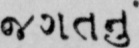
જગતનું
